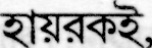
হায়রকই,
